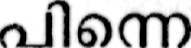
പിന്നെ
